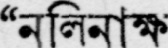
‘‘নলিনাক্ষ
